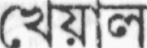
খেয়াল
